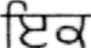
ਇਕ
